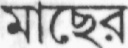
মাছের
